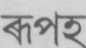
ৰূপহ
